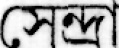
সেন্দ্রা
